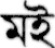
মই
